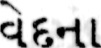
વેદના
